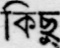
কিছু
